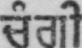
ਚੰਗੀ
